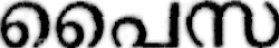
പൈസ
